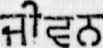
ਜੀਵਨ
